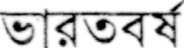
ভারতবর্ষ
